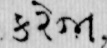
કરેજા,
